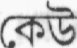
কেউ
